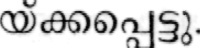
യ്ക്കപ്പെട്ടു.
